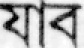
যাব
